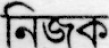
নিজক
